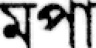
মপা
